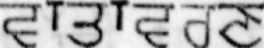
ਵਾਤਾਵਰਣ
